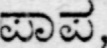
ಪಾಪ,
